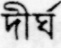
দীর্ঘ
